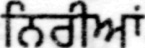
ਨਿਰੀਆਂ
